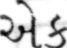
એક
